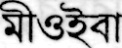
মীওইবা
